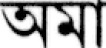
অমা
